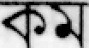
কম
